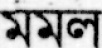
মমল
